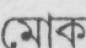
মোক
